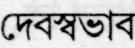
দেবস্বভাব
